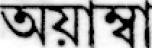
অয়াম্বা
